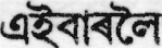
এইবাৰলৈ
